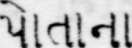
પોતાના
